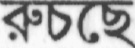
রুচছে
